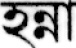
হন্না
